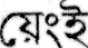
য়েংই
